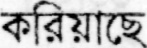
করিয়াছে
